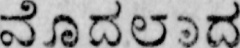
ಮೊದಲಾದ
